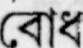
বোধ
